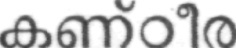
കണ്ഠീര
